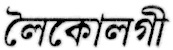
লৈকোলগী
